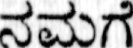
ನಮಗೆ
